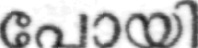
പോയി
